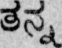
ತನ್ನ
